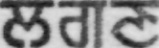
ਲਗਣ
